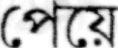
পেয়ে
